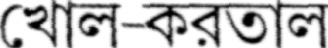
খোল-করতাল
